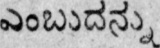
ಎಂಬುದನ್ನು
